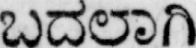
ಬದಲಾಗಿ
